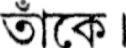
তাঁকে।
